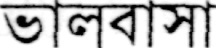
ভালবাসা
